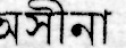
অসীনা
